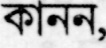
কানন,
